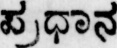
ಪ್ರಧಾನ
